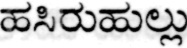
ಹಸಿರುಹುಲ್ಲು
